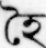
হৈ
